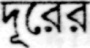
দূরের
